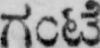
ಗಂಟೆ
